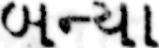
બન્યા
